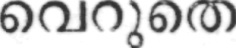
വെറുതെ
